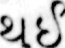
થઈ
